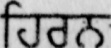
ਹਿਰਨ
